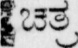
ಚತ್ರ
